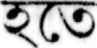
হতে
